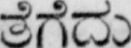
ತೆಗೆದು
